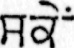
ਸਕੇਂ
